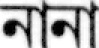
নানা
